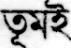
তূমই
